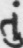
તું
